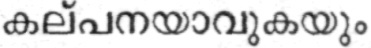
കല്പനയാവുകയും
